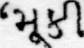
'મૂકી
